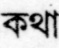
কথা
